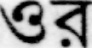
ওর
